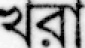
খরা
